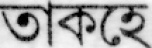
তাকহে
